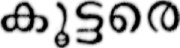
കൂട്ടരെ
